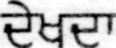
ਦੇਖਦਾ
